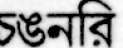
চঙনরি
